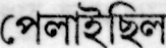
পেলাইছিল
